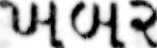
ખબર
